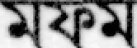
মফম
